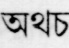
অথচ
